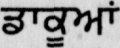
ਡਾਕੂਆਂ
